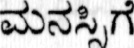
ಮನಸ್ಸಿಗೆ
